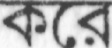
করে
